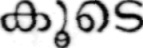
കൂടെ
